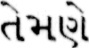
તેમણે
